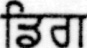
ਡਿਗ
